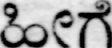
ಹೀಗೆ
